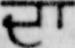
ਦਾ
